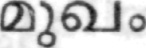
മുഖം
